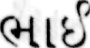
ભાઈ
